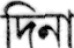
দিনা
